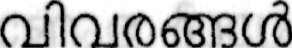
വിവരങ്ങള്‍
